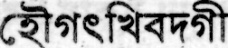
হৌগৎখিবদগী
